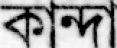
কান্দা
